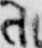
તો
